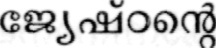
ജ്യേഷ്ഠന്റെ
